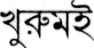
খুরুমই
